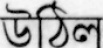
উঠিল
